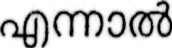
എന്നാല്‍
